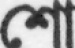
শো
